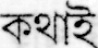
কথাই
